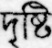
দৃষ্টি
